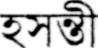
হসন্তী
